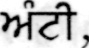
ਅੰਟੀ,
